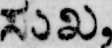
ಸುಖ,
